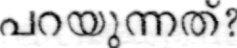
പറയുന്നത്?
